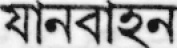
যানবাহন
